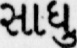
સાધુ
